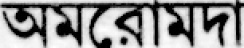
অমরোমদা
